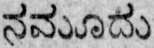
ನಮೂದು
